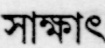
সাক্ষাত্
